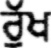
ਰੁੱਖ
